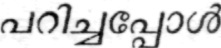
പറിച്ചപ്പോള്‍
